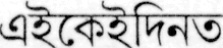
এইকেইদিনত
